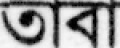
তাবা
